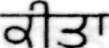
ਕੀਤਾ
